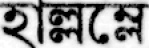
হাল্লম্লে
